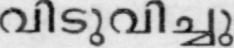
വിടുവിച്ചു
